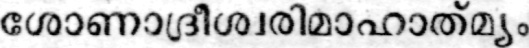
ശോണാദ്രീശ്വരിമാഹാത്മ്യം
